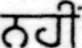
ਨਹੀਂ
